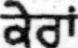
ਕੇਰਾਂ
